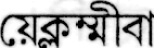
য়েক্লম্মীবা
